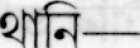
থানি-
